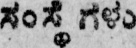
ಸಂಸ್ಥೆಗಳು
